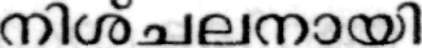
നിശ്ചലനായി
